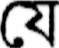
যে
